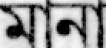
মানা
